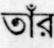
তাঁর
